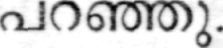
പറഞ്ഞു.
